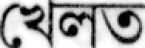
খেলত
